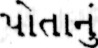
પોતાનું
